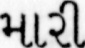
મારી
